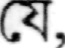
যে,
